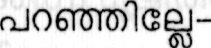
പറഞ്ഞില്ലേ-
